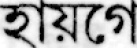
হায়গে
